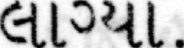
લાગ્યા.
